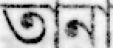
তানা
